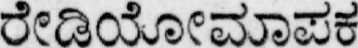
ರೇಡಿಯೋಮಾಪಕ
